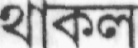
থাকল
